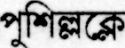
পুশিল্লক্লে
